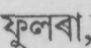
ফুলৰা,
